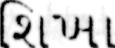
શિખા
